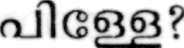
പിള്ളേ?
